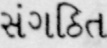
સંગઠિત
